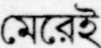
মেরেই
